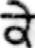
ਕੇ
